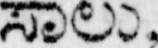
ಸಾಲು,
